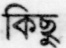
কিছু
